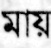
মায়
